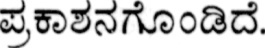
ಪ್ರಕಾಶನಗೊಂಡಿದೆ.
